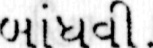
બાંધવી.
